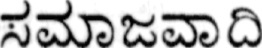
ಸಮಾಜವಾದಿ
